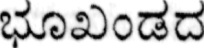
ಭೂಖಂಡದ
